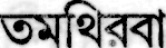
তমথিরবা
